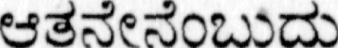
ಅತನೇನೆಂಬುದು
